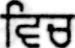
ਵਿਚ
